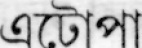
এটোপা
